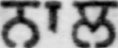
ਨਾਲ
